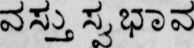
ವಸ್ತುಸ್ವಭಾವ
